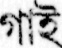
গাই
